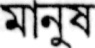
মানুষ
